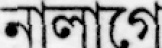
নালাগে
